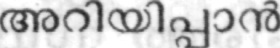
അറിയിപ്പാന്‍
